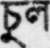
চুল
